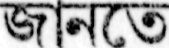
জানতে
